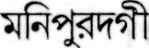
মণিপরদগী
